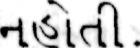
નહોતી.
